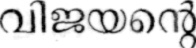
വിജയന്റെ
